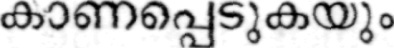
കാണപ്പെടുകയും
